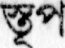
স্তূপ
